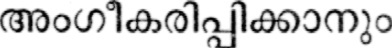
അംഗീകരിപ്പിക്കാനും
